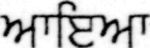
ਆਇਆ
